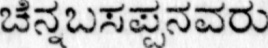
ಚೆನ್ನಬಸಪ್ಪನವರು
